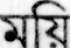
ময়ি
